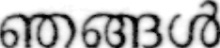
ഞങ്ങള്‍
